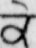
ਕੇ
